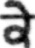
ਕੇ
